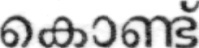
കൊണ്ട്
